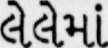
લેલેમાં
